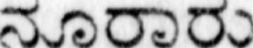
ನೂರಾರು
